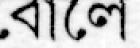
বোলে
